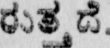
ರುತ್ತದೆ.
